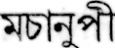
মচানুপী
